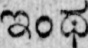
ಇಂಥ
